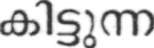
കിട്ടുന്ന
